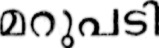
മറുപടി
